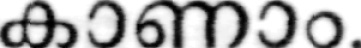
കാണാം.
